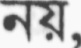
নয়,
